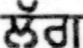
ਲੱਗ
